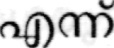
എന്ന്
